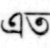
এত
